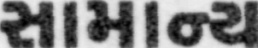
સામાન્ય
